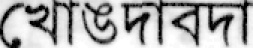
খোঙদাবদা
